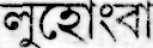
লুহোংবা
